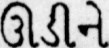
ઊડીને
